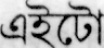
এইটো
